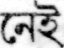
নেই
